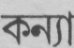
কন্যা
